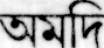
অমদি
